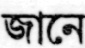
জানে
